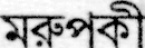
মরুপকী
